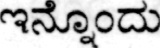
ಇನ್ನೊಂದು
